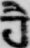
ਹੈ
